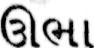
ઊભા
